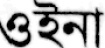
ওইনা
